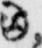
છે,
